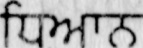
ਧਿਆਨ
